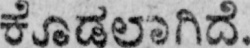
ಕೊಡಲಾಗಿದೆ.
